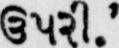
ઉપરી.'
